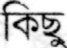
কিছু
